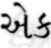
એક
